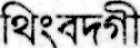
থিংবদগী
